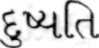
દુષ્યતિ
